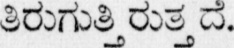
ತಿರುಗುತ್ತಿರುತ್ತದೆ.
